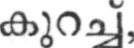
കുറച്ച്,
